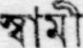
স্বামী
